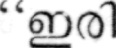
“ഇരി
